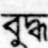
বুদ্ধ
